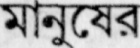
মানুষের
